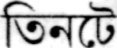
তিনটে
